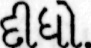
દીધો.
